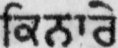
ਕਿਨਾਰੇ
